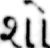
શો
